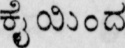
ಕೈಯಿಂದ
